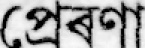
প্রেৰণা
